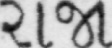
રાજા
